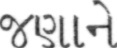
જણાને
